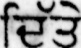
ਦਿੱਤੇ
